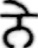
ਨੇ
